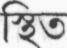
স্থিত
